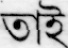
তাই
